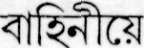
বাহিনীয়ে
